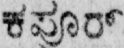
ಕಪೂರ್
